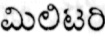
ಮಿಲಿಟರಿ
